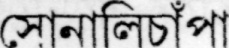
সোনালিচাঁপা
